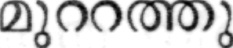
മുററത്തു
